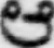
ಆ
